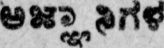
ಅಜ್ಞಾನಿಗಳ
